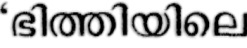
‘ഭിത്തിയിലെ
